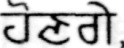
ਹੋਣਗੇ,
